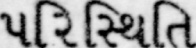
પરિસ્થિતિ
